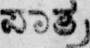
ಪಾತ್ರ
